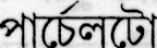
পাৰ্চেলটো
